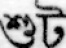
শুট
